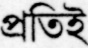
প্রতিই
